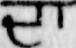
ਦਾ
